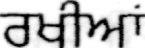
ਰਖੀਆਂ
